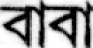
বাবা
